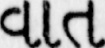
વાત
